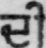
ਦੀ
